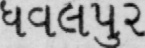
ધવલપુર
